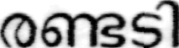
രണ്ടടി
